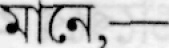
মানে,-
